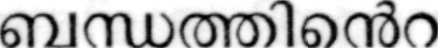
ബന്ധത്തിന്റെ
